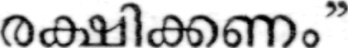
രക്ഷിക്കണം”
